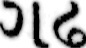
ગઢ
